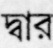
দ্বার
